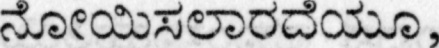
ನೋಯಿಸಲಾರದೆಯೂ,
